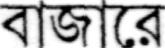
বাজারে
